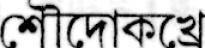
শৌদোকখ্রে
